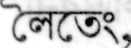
লৈতেং,
